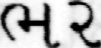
ભર
